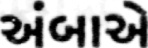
અંબાએ
